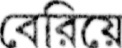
বেরিয়ে
